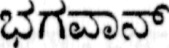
ಭಗವಾನ್
